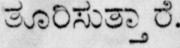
ತೂರಿಸುತ್ತಾರೆ.
